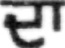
ਦਾ
